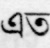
এত
